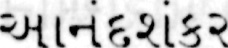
આનંદશંકર
